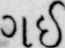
ગઈ
